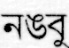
নঙবু
